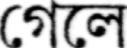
গেলে
